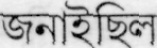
জনাইছিল
